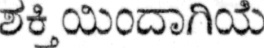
ಶಕ್ತಿಯಿಂದಾಗಿಯೆ
